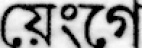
য়েংগে
